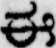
ಈ
